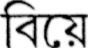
বিয়ে
